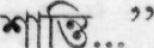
শান্তি.."
